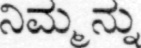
ನಿಮ್ಮನ್ನು
